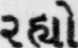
રહ્યો
